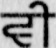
ਵੀ
